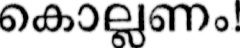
കൊല്ലണം!
